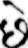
છે
